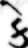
કે
